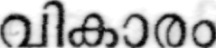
വികാരം
